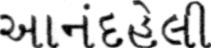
આનંદહેલી
